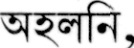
অহলনি,
